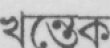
খন্তেক
